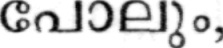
പോലും,
